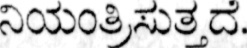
ನಿಯಂತ್ರಿಸುತ್ತದೆ.
